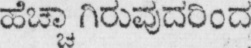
ಹೆಚ್ಚಾಗಿರುವುದರಿಂದ
